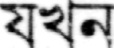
যখন
